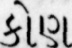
કોણ
